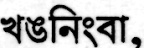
খঙনিংবা,
